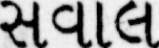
સવાલ
